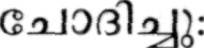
ചോദിച്ചു:
